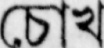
চোখ
